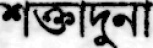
শক্তাদুনা
